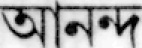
আনন্দ
